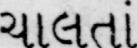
ચાલતાં
